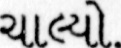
ચાલ્યો.
